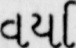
વર્યા
